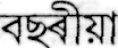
বছৰীয়া
